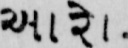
આરો;
